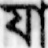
যা
